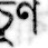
চুণ
